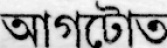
আগটোত
